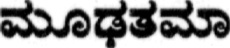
ಮೂಢತಮಾ
